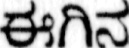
ಈಗಿನ
